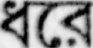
ধরে
